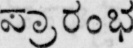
ಪ್ರಾರಂಭ
